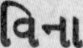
વિના
